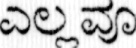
ಎಲ್ಲವೂ
